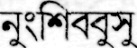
নুংশিববুসু
